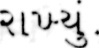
રાંખ્યું.
